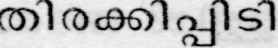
തിരക്കിപ്പിടി
